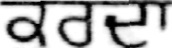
ਕਰਦਾ
